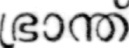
ഭ്രാന്ത്
